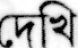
দেখি
